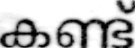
കണ്ട്
